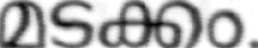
മടക്കം.
